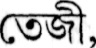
তেজী,
